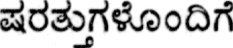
ಷರತ್ತುಗಳೊಂದಿಗೆ
